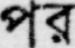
পর
